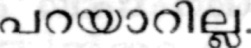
പറയാറില്ല.
